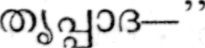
തൃപ്പാദ-"
